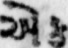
એક
